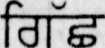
ਗਿੱਛ
